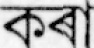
কৰা
